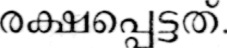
രക്ഷപ്പെട്ടത്.
